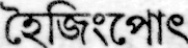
হৈজিংপোৎ
